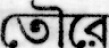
তৌরে
